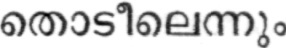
തൊടീലെന്നും
